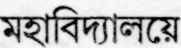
মহাবিদ্যালয়ে
